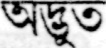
অদ্ভুত
